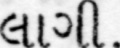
લાગી.
